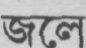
জলে
